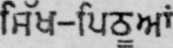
ਸਿੱਖ-ਪਿਠੂਆਂ
